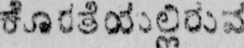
ಕೊರತೆಯಲ್ಲಿರುವ
